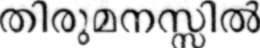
തിരുമനസ്സില്‍
